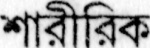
শারীরিক
